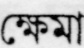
ক্ষেমা
